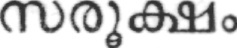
സരൂക്ഷം
